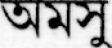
অমসু
